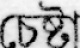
চেষ্টা
